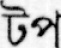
টপ
